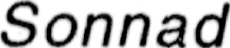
Sonnad
